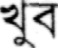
খুব
